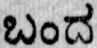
ಬಂದ
